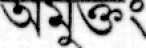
অমুক্তং
